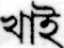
খাই
